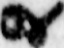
જ
